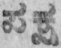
ಪಕ್ಷ
